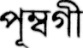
পূম্বগী
